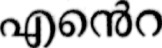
എന്റെ
